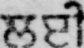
ਲਈ
